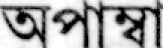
অপাম্বা
